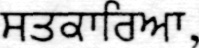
ਸਤਕਾਰਿਆ,
